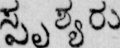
ಸ್ಪೃಶ್ಯರು
